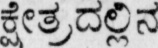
ಕ್ಷೇತ್ರದಲ್ಲಿನ
